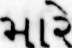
મારે
